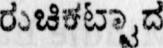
ರುಚಿಕಟ್ಟಾದ
